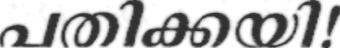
പതിക്കയി!
